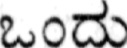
ಒಂದು
